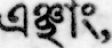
এঞ্ছাং,
